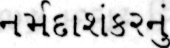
નર્મદાશંકરનું
